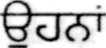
ਉਹਨਾਂ
